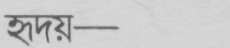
হৃদয়-
